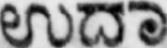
ಉದಾ
